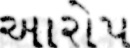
આરોપ
